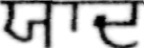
ਯਾਦ
